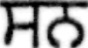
ਸਨ
